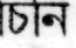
চিনি
